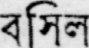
বসিল
